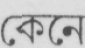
কেনে
